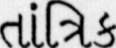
તાંત્રિક
